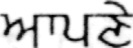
ਆਪਣੇ
